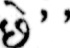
છે"
